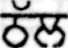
ਠੱਲ
